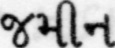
જમીન
